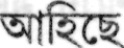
আহিছে
